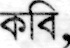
কবি,
